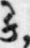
કે,
